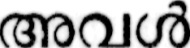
അവള്‍
